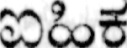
ಐಹಿಕ
